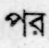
পর
